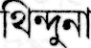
থিন্দুনা
